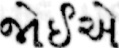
જોઈએ
